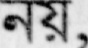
নয়,
